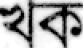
খক
